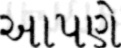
આપણે
